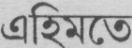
এহিমতে
